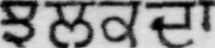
ਝਲਕਦਾ
